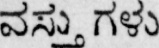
ವಸ್ತುಗಳು
